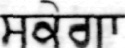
ਸਕੇਗਾ
